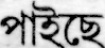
পাইছে
